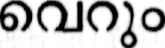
വെറും
